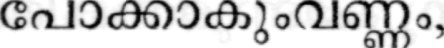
പോക്കാകുംവണ്ണം,
